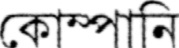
কোম্পানি
